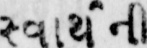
સ્વાર્થની
